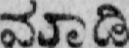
ಮಾಡಿ
